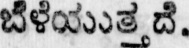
ಬೆಳೆಯುತ್ತದೆ.
